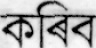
কৰিব
